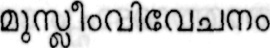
മുസ്ലീംവിവേചനം
